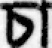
চা
